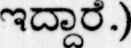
ಇದ್ದಾರೆ.)
